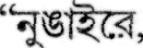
“নুঙাইরে,
